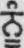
ਨੂੰ
